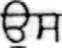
ਉਸ
